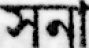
সনা
